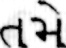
તમે
